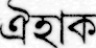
ঐহাক
